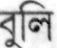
বুলি
